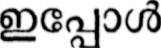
ഇപ്പോള്‍
